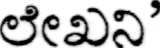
ಲೇಖನಿ'
